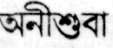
অনীশুবা
